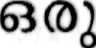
ഒരു
